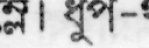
অপূনবা,
